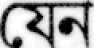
যেন
